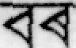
বৰ
